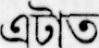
এটাত
